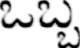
ಒಬ್ಬ
